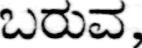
ಬರುವ,
